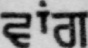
ਵਾਂਗ
